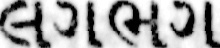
લગભગ
